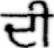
ਦੀ
